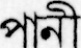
পানী
